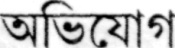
অভিযোগ
